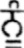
ਨੂੰ
